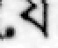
যে
